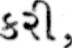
કરી,
